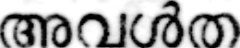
അവള്‍ത
